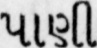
પાણી
